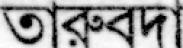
তারুবদা
